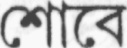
শোবে
